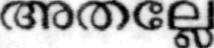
അതല്ലേ
